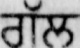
ਗੱਲ
